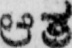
ಆತ
